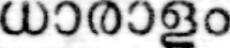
ധാരാളം
